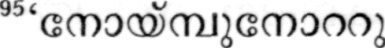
95'നോയ്മ്പുനോററു
